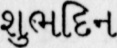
શુભદિન
